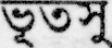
ভুতসু
